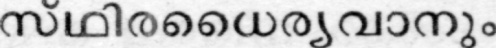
സ്ഥിരധൈര്യവാനും
